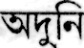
অদুনি
